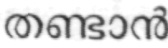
തണ്ടാന്‍
